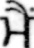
ਮੈਂ
